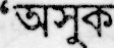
‘অসুক
